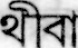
থীবা
